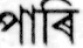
পাৰি
